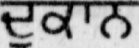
ਦੁਕਾਨ
